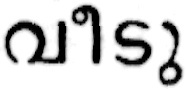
വീടു
